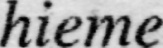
hieme
